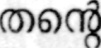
തന്റെ
